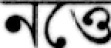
নত্তে
